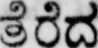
ತೆರೆದ
